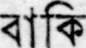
বাকি
